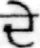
ਦੇ
